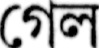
গেল
